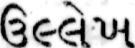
ઉલ્લેખ
